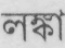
লঙ্কা
